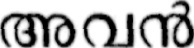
അവന്‍
